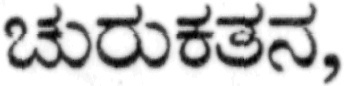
ಚುರುಕತನ,
